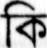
কি
